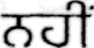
ਨਹੀਂ
